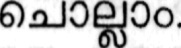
ചൊല്ലാം.
